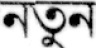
নতুন
